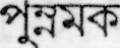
পুম্নমক
